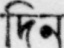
দিন
